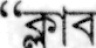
"ক্লাব
